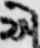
એ
